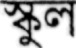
স্কুল
